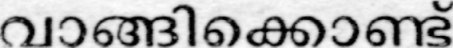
വാങ്ങിക്കൊണ്ട്
